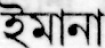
ইমানা
